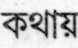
কথায়
